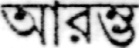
আরম্ভ
